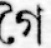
গৈ
